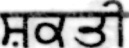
ਸ਼ਕਤੀ
